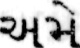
અમે
